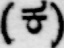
(ಕ)
